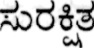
ಸುರಕ್ಷಿತ
